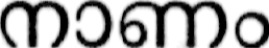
നാണം
